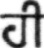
ਹੀ
